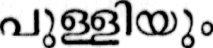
പുള്ളിയും
